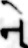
ને
